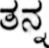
ತನ್ನ
